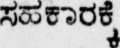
ಸಹಕಾರಕ್ಕೆ
